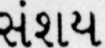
સંશય
